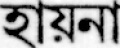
হায়না
